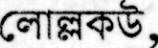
লোল্লকউ,
